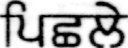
ਪਿਛਲੇ
